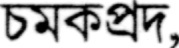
চমকপ্রদ,
